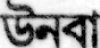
উনবা
